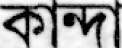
কান্দা
